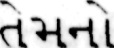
તેમનો
